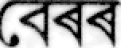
বেৰৰ
